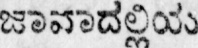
ಜಾವಾದಲ್ಲಿಯ
